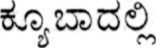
ಕ್ಯೂಬಾದಲ್ಲಿ
